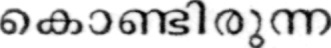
കൊണ്ടിരുന്ന
